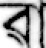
ৱা
